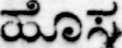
ಹೊಸ
